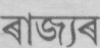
ৰাজ্যৰ
